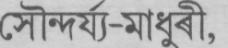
সৌন্দৰ্য্য-মাধুৰী,
